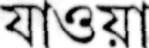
যাওয়া
